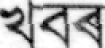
খবৰ
